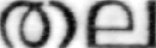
തല
